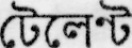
টেলেন্ট
